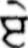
ਏ
